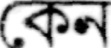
কেন
